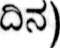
ದಿನ)
